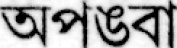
অপঙবা
